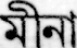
মীনা
